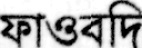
ফাওবদি
